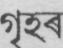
গৃহৰ
